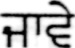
ਜਾਵੇ
